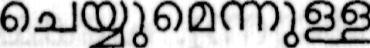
ചെയ്യുമെന്നുള്ള
